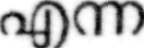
എന്ന
